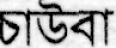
চাউবা
